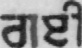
ਗਈ
